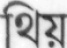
থিয়
